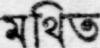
মথিত
